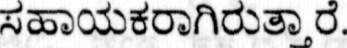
ಸಹಾಯಕರಾಗಿರುತ್ತಾರೆ.
